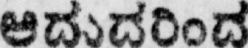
ಅದುದರಿಂದ
